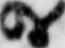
જ
